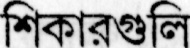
শিকারগুলি
